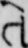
તે
